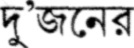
দু’জনের
